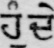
ਹੁੰਦੇ
